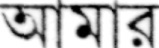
আমার
